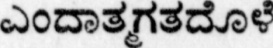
ಎಂದಾತ್ಮಗತದೊಳೆ
